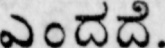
ಎಂದದೆ.
